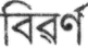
বিৱর্ণ
